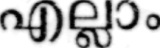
എല്ലാം
